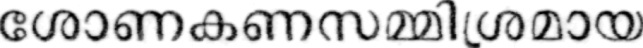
ശോണകണസമ്മിശ്രമായ
